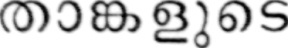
താങ്കളുടെ
